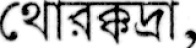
থোরক্কদ্রা,
